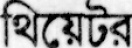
থিয়েটর
